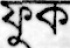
ফুক
